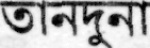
তানদুনা
